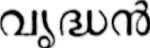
വൃദ്ധന്‍
